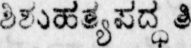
ಶಿಶುಹತ್ಯಪದ್ಧತಿ
